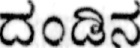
ದಂಡಿನ
